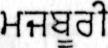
ਮਜਬੂਰੀ
